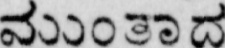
ಮುಂತಾದ
